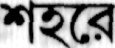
শহরে
